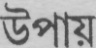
উপায়
